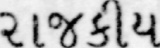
રાજકીય
